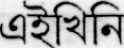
এইখিনি
